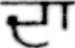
ਦਾ
